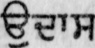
ਉਦਾਸ
